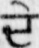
ਦੇ
